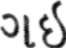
ગઈ
